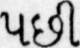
પછી
